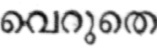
വെറുതെ
